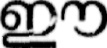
ഈ
